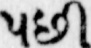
પછી
